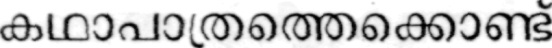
കഥാപാത്രത്തെക്കൊണ്ട്
